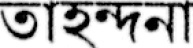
তাহন্দনা
